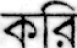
করি
